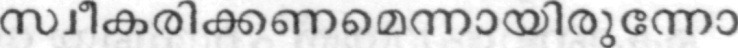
സ്വീകരിക്കണമെന്നായിരുന്നോ
